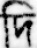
দি
